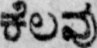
ಕೆಲವು
